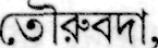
তৌরুবদা,
